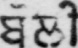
ਬੋਲੀ
